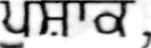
ਪੁਸ਼ਾਕ,
